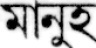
মানুহ
